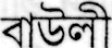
বাউলী
